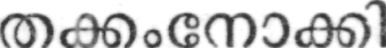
തക്കംനോക്കി
